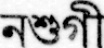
নশুগী
